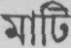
মাটি
